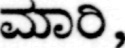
ಮಾರಿ,
